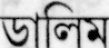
ডালিম
